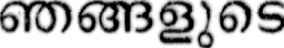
ഞങ്ങളുടെ
